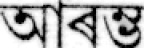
আৰম্ভ
